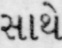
સાથે
